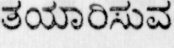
ತಯಾರಿಸುವ
